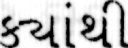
ક્યાંથી
